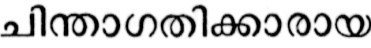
ചിന്താഗതിക്കാരായ
